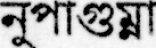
নুপাগুম্না
